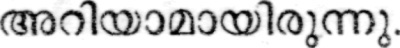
അറിയാമായിരുന്നു.
